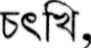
চৎখি,
